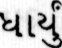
ધાર્યું
